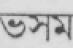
ভসম
